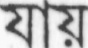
যায়
